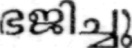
ഭജിച്ചു
